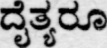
ದೈತ್ಯರೂ
